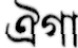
ঐগা
